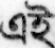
এই
